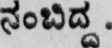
ನಂಬಿದ್ದ.
